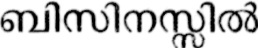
ബിസിനസ്സില്‍
